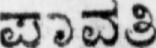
ಪಾವತಿ
